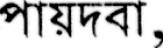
পায়দবা,
